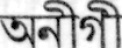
অনীগী
